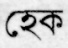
হেক
